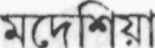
মদেশিয়া
